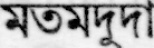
মতমদুদা
